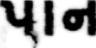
પાન
